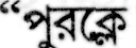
“পুরক্লে
